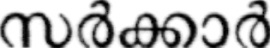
സര്‍ക്കാര്‍
